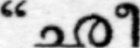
"ഛീ
